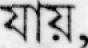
যায়,
